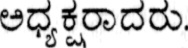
ಅಧ್ಯಕ್ಷರಾದರು.
